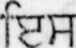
ਇਸ
